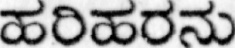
ಹರಿಹರನು
